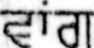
ਵਾਂਗ
